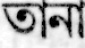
তানা
